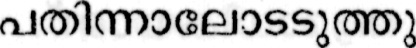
പതിന്നാലോടടുത്തു
